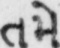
તમે
